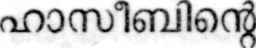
ഹാസീബിന്റെ
